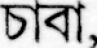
চাবা,
